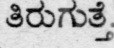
ತಿರುಗುತ್ತೆ.
